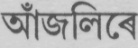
আঁজলিৰে
